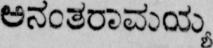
ಅನಂತರಾಮಯ್ಯ
